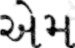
એમ
